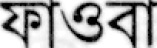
ফাওবা
